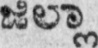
ಜಿಲ್ಲಾ
